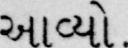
આવ્યો.
